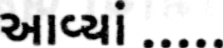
આવ્યાં...
